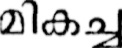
മികച്ച
